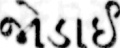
જોડાઈ
